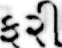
ફરી
